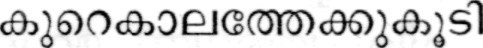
കുറെകാലത്തേക്കുകൂടി
